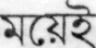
ময়েই
